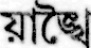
য়াঙ্খৈ
